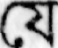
যে
